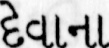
દેવાના
